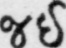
જઈ
